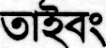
তাইবং
